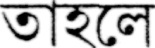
তাহলে
